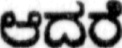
ಆದರೆ
